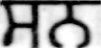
ਸਨ
